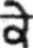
ਕੇ
